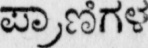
ಪ್ರಾಣಿಗಳ
